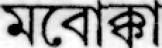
মবোক্কা
